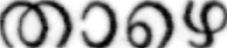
താഴെ
